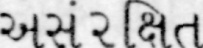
અસંરક્ષિત
